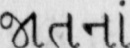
જાતનાં
